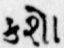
કશો
